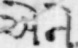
એને
